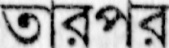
তারপর
